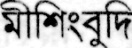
মীশিংবুদি
